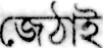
জেঠাই
